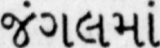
જંગલમાં
